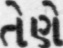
તેણે
